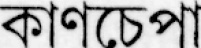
কাণচেপা
